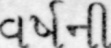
વર્ષની
